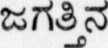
ಜಗತ್ತಿನ
